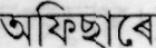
অফিছাৰে
